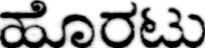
ಹೊರಟು
